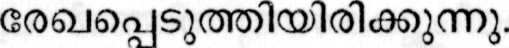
രേഖപ്പെടുത്തിയിരിക്കുന്നു.
